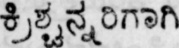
ಕ್ರಿಶ್ಚನ್ನರಿಗಾಗಿ
